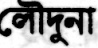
লৌদুনা
